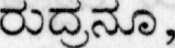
ರುದ್ರನೂ,
